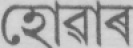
হোৱাৰ
